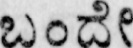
ಬಂದೇ
